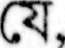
যে,
